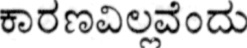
ಕಾರಣವಿಲ್ಲವೆಂದು
